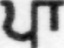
ਪਾ
